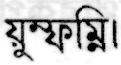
য়ুম্ফম্নি।
